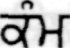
ਕੰਮ
